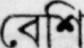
বেশি
